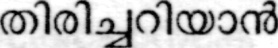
തിരിച്ചറിയാന്‍
